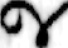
જ
